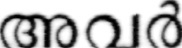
അവര്‍
